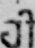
ਹੀ
